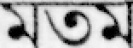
মতম
